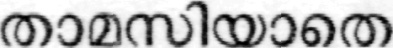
താമസിയാതെ
